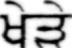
ਖੇੜੇ
